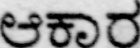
ಆಕಾರ
